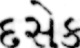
દસેક
